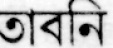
তাবনি
